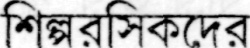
শিল্পরসিকদের
